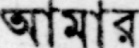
আমার
